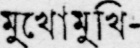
মুখোমুখি-
